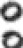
ঃ
